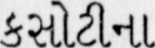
કસોટીના
